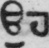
ਉਹ
